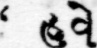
'હવે
